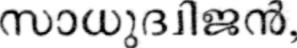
സാധുദ്വിജന്‍,
